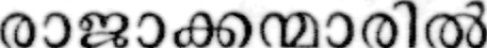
രാജാക്കന്മാരില്‍
